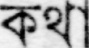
কথা
